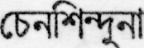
চেনশিন্দুনা
